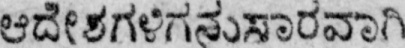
ಆದೇಶಗಳಿಗನುಸಾರವಾಗಿ
